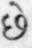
છે
